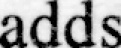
adds
